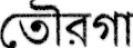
তৌরগা
